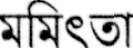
মমিৎতা
